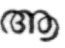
ആ
